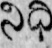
ನಿಧಿ
